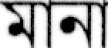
মানা
